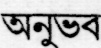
অনুভব
